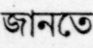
জানতে
